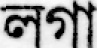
লগা
